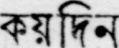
কয়দিন
